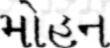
મોહન
